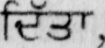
ਦਿੱਤਾ,
